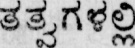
ತತ್ವಗಳಲ್ಲಿ
